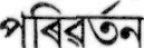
পৰিৱর্তন
